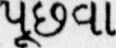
પૂછવા
